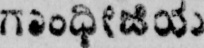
ಗಾಂಧೀಜಿಯ
